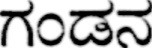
ಗಂಡನ
